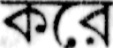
করে
